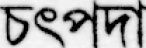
চৎপদা
